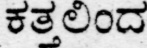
ಕತ್ತಲಿಂದ
